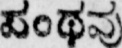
ಪಂಥವು
